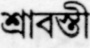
শ্রাবস্তী
